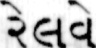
રેલ્વે
